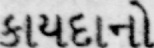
કાયદાનો
